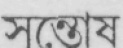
সন্তোষ
